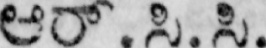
ಆರ್.ಸಿ.ಸಿ
